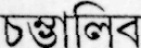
চম্ভালিব
